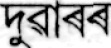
দুৱাৰৰ
